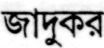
জাদুকর
